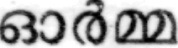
ഓര്‍മ്മ
